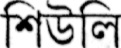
শিউলি
